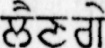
ਲੈਣਗੇ
